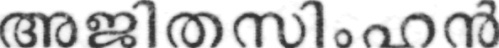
അജിതസിംഹന്‍
